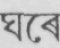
ঘৰে
